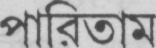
পারিতাম
